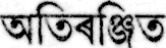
অতিৰঞ্জিত
